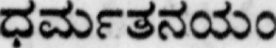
ಧರ್ಮತನಯಂ
